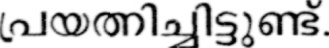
പ്രയത്നിച്ചിട്ടുണ്ട്.
